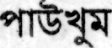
পাউখুম
